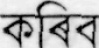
কৰিব
